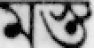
মস্ত
